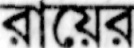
রায়ের
